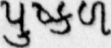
પુષ્કળ
